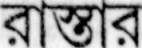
রাস্তার
